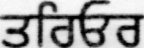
ਤਰਿਓਰ
